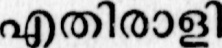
എതിരാളി
